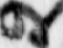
જ
